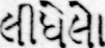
લીધેલો
